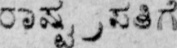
ರಾಷ್ಟ್ರಪತಿಗೆ
